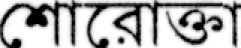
শোরোক্তা
